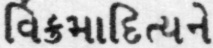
વિક્રમાદિત્યને
